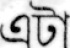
এটা
